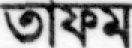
তাফম
